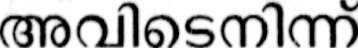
അവിടെനിന്ന്
